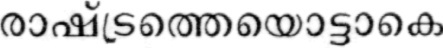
രാഷ്ട്രത്തെയൊട്ടാകെ
